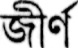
জীর্ণ
